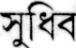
সুধিব
